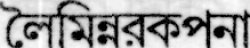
লৈমিন্নরকপনা
